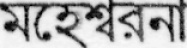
মহেশ্বরনা
